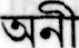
অনী
